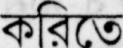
করিতে
